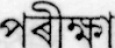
পৰীক্ষা
